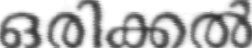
ഒരിക്കല്‍
